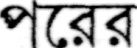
পরের
